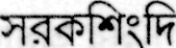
সরকশিংদি
